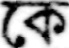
কে
